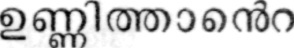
ഉണ്ണിത്താന്റെ
